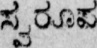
ಸ್ವರೂಪ
